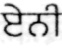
ਏਨੀ
